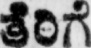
ತೆರಿಗೆ
